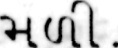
મળી.
